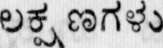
ಲಕ್ಷಣಗಳು
